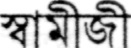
স্বামীজী
